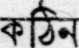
কঠিন
